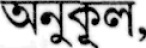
অনুকূল,
